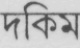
দকিম
